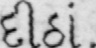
દીઠાં.
